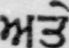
ਅਤੇ
